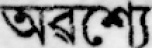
অৱশ্যে
